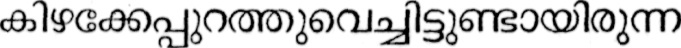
കിഴക്കേപ്പുറത്തുവെച്ചിട്ടുണ്ടായിരുന്ന
